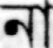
না
